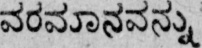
ವರಮಾನವನ್ನು
